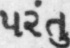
પરંતુ
